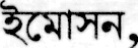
ইমোসন,
